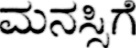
ಮನಸ್ಸಿಗೆ
